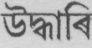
উদ্ধাৰি
